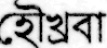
হৌখ্রবা
